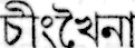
চীংখৈনা
